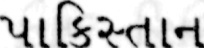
પાકિસ્તાન
